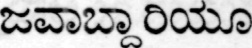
ಜವಾಬ್ದಾರಿಯೂ
